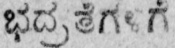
ಭದ್ರತೆಗಳಿಗೆ
